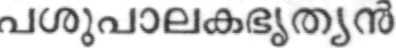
പശുപാലകഭൃത്യന്‍
